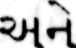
અને
